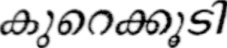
കുറെക്കൂടി
